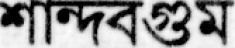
শান্দবগুম
